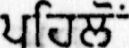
ਪਹਿਲੋਂ
